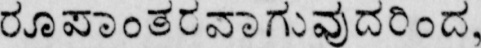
ರೂಪಾಂತರವಾಗುವುದರಿಂದ,
